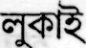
লুকাই
